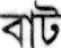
বাট
